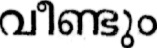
വീണ്ടും
